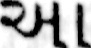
આ
